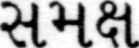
સમક્ષ
